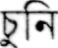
চুনি
